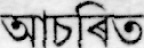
আচৰিত
